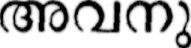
അവനു
